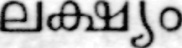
ലക്ഷ്യം
